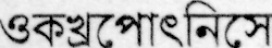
ওকখ্রপোৎনিসে
